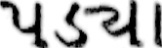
પડ્યા
